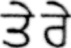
ਤੇਰੇ
